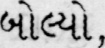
બોલ્યો,
